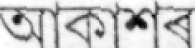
আকাশৰ
